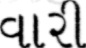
વારી
